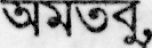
অমতবু,
